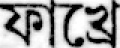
ফাখ্রে
